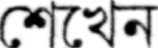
শেখেন
